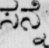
ಸನ್ನೆ
